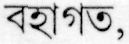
বহাগত,
